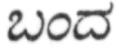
ಬಂದ
